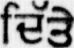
ਦਿੱਤੇ
